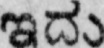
ಇದು
